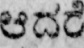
ಆದರೆ
